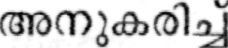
അനുകരിച്ച്
